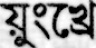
য়ুংখ্রে
